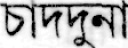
চাদদুনা
